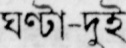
ঘন্টা-দুই
